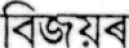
বিজয়ৰ
